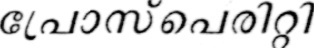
പ്രോസ്പെരിറ്റി
